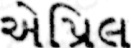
એપ્રિલ
